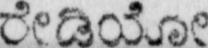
ರೇಡಿಯೋ
